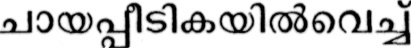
ചായപ്പീടികയില്‍വെച്ച്
